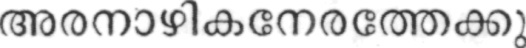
അരനാഴികനേരത്തേക്കു
